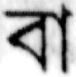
বা
